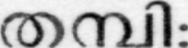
തമ്പി:
